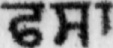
ਫਸਾ
